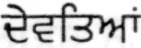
ਦੇਵਤਿਆਂ
